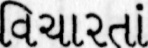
વિચારતાં
